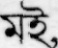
মই,
